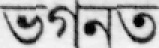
ভগনত
